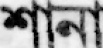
শানা
